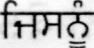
ਜਿਸਨੂੰ
